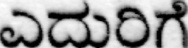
ಎದುರಿಗೆ
